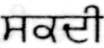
ਸਕਦੀ
